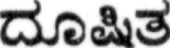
ದೂಷಿತ
